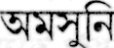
অমসুনি
